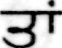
ਤਾਂ
